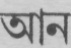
আন
